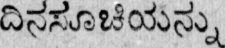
ದಿನಸೂಚಿಯನ್ನು
